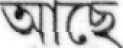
আছে
